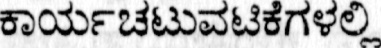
ಕಾರ್ಯಚಟುವಟಿಕೆಗಳಲ್ಲಿ
